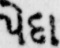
પેદા
